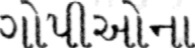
ગોપીઓના
